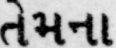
તેમના
